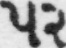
પર
